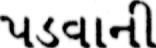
પડવાની
